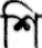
শি
